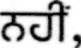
ਨਹੀਂ,
